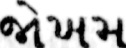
જોખમ
